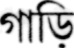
গাড়ি
